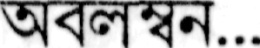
অবলম্বন...
